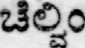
ಚೆಲ್ವಿಂ
